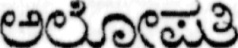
ಅಲೋಪತಿ
